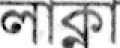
লাক্না
